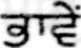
ਭਾਵੇਂ
